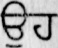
ਉਹ
